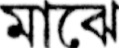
মাঝে
